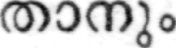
താനും
